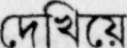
দেখিয়ে
